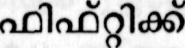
ഫിഫ്റ്റിക്ക്
